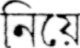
নিয়ে
